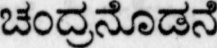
ಚಂದ್ರನೊಡನೆ
